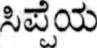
ಸಿಪ್ಪೆಯ
